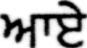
ਆਏ
